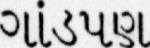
ગાંડપણ
